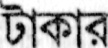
টাকার
